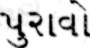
પુરાવો
